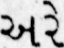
'અરે
